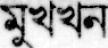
মুখখন
